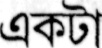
একটা
